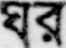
ঘর
